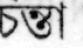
চন্তা
